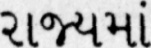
રાજ્યમાં
